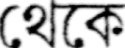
থেকে
